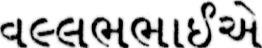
વલ્લભભાઈએ
